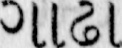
ગાઢા
